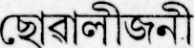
ছোৱালীজনী
